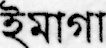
ইমাগা
